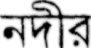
নদীর
